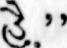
હૈ."
